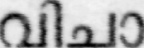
വിചാ
